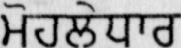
ਮੋਹਲੇਧਾਰ
